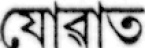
যোৱাত
